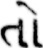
તો
